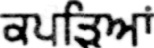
ਕਪੜਿਆਂ
